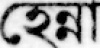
হেন্না
